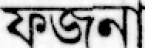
ফজনা
